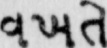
વખતે
